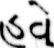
હવે
